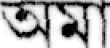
অমা
